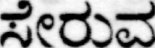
ಸೇರುವ
